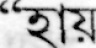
“হায়
